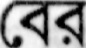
বের
